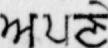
ਅਪਣੇ
